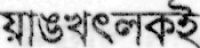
য়াঙখৎলকই
